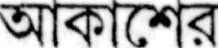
আকাশের
